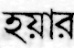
হয়ার
